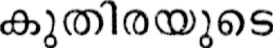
കുതിരയുടെ
